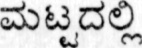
ಮಟ್ಟದಲ್ಲಿ
